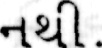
નથી.
